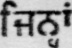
ਜਿਨ੍ਹਾਂ
